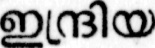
ഇന്ദ്രിയ
